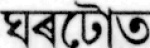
ঘৰটোত
